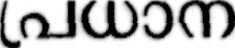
പ്രധാന
